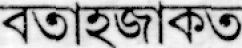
বতাহজাকত
